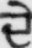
ਦੇ
